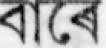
বাৰে
